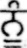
ਨੂੰ
